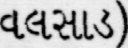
વલસાડ)
